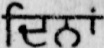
ਦਿਨਾਂ
